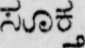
ಸೂಕ್ತ
